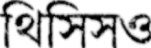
থিসিসও
